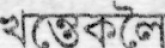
খন্তেকলৈ
